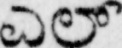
ಎಲ್
